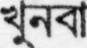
খু্নবা
